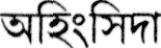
অহিংসিদা
